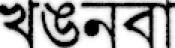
খঙনবা
